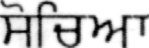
ਸੋਚਿਆ
